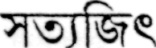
সত্যজিত্
